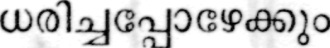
ധരിച്ചപ്പോഴേക്കും
